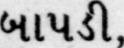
બાપડી,
